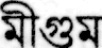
মীগুম
